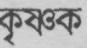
কৃষ্ণক
